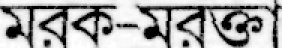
মরক-মরক্তা
